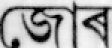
জোৰ
